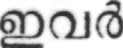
ഇവര്‍
